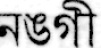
নঙগী
